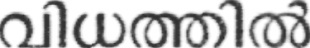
വിധത്തില്‍
